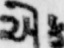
એક
